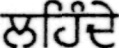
ਲਹਿੰਦੇ
